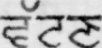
ਵੱਟਣ
